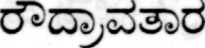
ರೌದ್ರಾವತಾರ
